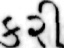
કરી
